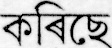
কৰিছে
